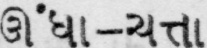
ઊંધા-ચત્તા
